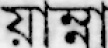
য়াম্না
